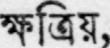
ক্ষত্রিয়,
